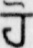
ਹੋ
